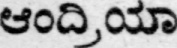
ಆ೦ದ್ರಿಯಾ
